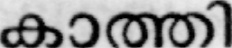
കാത്തി
